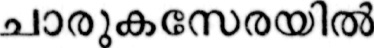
ചാരുകസേരയില്‍
